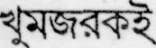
খুমজরকই
